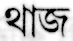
থাজ
